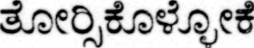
ತೋರ್ಸಿಕೊಳ್ಳೋಕೆ
